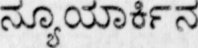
ನ್ಯೂಯಾರ್ಕಿನ
